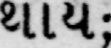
થાય;
